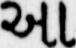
આ
